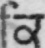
ਕਿ
